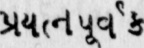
પ્રયત્નપૂર્વક
